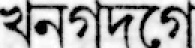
খনগদগে
